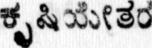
ಕೃಷಿಯೇತರ
